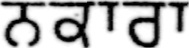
ਨਕਾਰਾ
